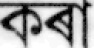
কৰা
